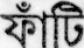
ফাঁটি
